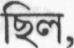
ছিল,
